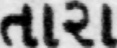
તારા
